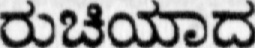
ರುಚಿಯಾದ
